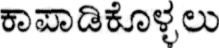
ಕಾಪಾಡಿಕೊಳ್ಳಲು
